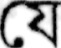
যে
